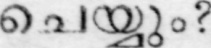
ചെയ്യും?
